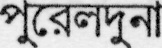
পূরেলদুন
